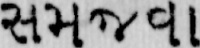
સમજવા
